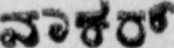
ವಾಕರ್
